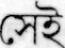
সেই
